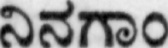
ನಿನಗಾಂ
